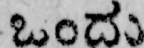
ಒಂದು
